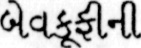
બેવકૂફીની
